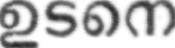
ഉടനെ
